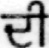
ਦੀ
